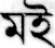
মই
